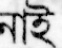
নাই
